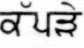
ਕੱਪੜੇ
